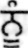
ਨੂੰ
